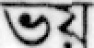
ভয়
